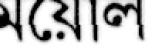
ময়োল
